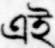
এই
